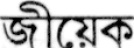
জীয়েক
